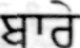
ਬਾਰੇ
